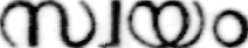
സ്വയം
